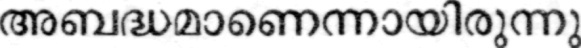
അബദ്ധമാണെന്നായിരുന്നു
